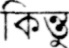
কিন্তু
